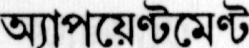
অ্যাপয়েণ্টমেণ্ট
